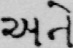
અને
